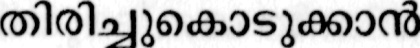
തിരിച്ചുകൊടുക്കാന്‍
